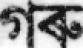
গৰু
